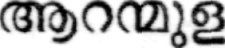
ആറന്മുള
